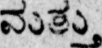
ಮತ್ತು
